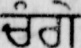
ਚੰਗੇ
